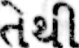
તેથી
